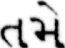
તમે
